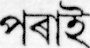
পৰাই
